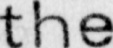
the
